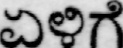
ಏಳಿಗೆ
